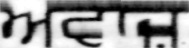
ਅਵਾਜ਼
